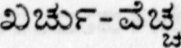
ಖರ್ಚು-ವೆಚ್ಚ
